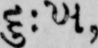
દુઃખ,
